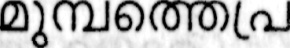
മുമ്പത്തെപ്ര
